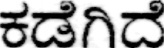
ಕಡೆಗಿದೆ
